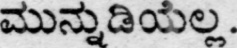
ಮುನ್ನುಡಿಯೆಲ್ಲ.
